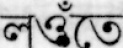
লওঁতে
